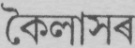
কৈলাসৰ
